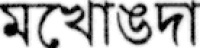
মখোঙদা
